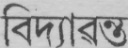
বিদ্যাৱন্ত
